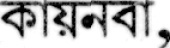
কায়নবা,
